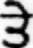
ਤੇ
